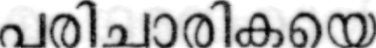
പരിചാരികയെ
